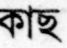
কাছ
